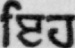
ਇਹ
